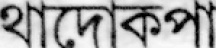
থাদোকপা
